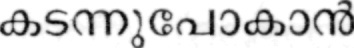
കടന്നുപോകാന്‍
